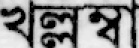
খল্লম্বা
